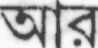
আর
